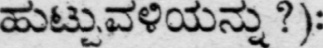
ಹುಟ್ಟುವಳಿಯನ್ನು?):
